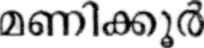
മണിക്കൂര്‍
